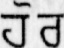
ਹੋਰ
